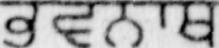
ਭਵਨਾਥ
